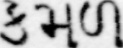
કમળ
